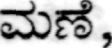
ಮಣೆ,
